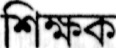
শিক্ষক
